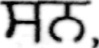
ਸਨ,
